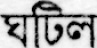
ঘটিল
